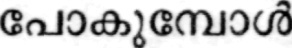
പോകുമ്പോള്‍
